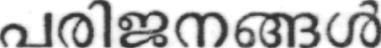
പരിജനങ്ങള്‍
